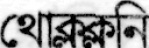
থোক্লক্লনি
